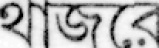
থাজরে
